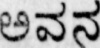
ಅವನ
